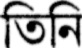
তিনি
